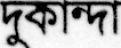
দুকান্দা
